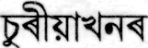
চুৰীয়াখনৰ
